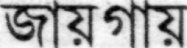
জায়গায়
